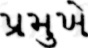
પ્રમુખે
